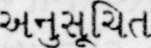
અનુસૂચિત
